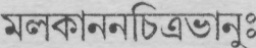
মলকাননচিত্ৰভানুঃ
